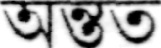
অন্তত
